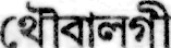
থৌবালগী
